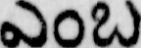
ಎಂಬ
